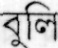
বুলি
